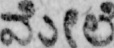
ಮೇಲೆ
